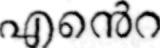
എന്റെ
